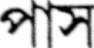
পাস
